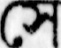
সে
